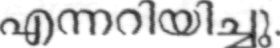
എന്നറിയിച്ചു.
